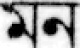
মন
